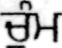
ਚੁੰਮ
